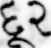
દૂર
